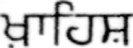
ਖ਼ਾਹਿਸ਼
